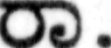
ರಾ.
